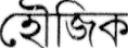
হৌজিক
